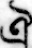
ঐ
